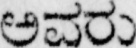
ಅವರು
